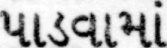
પાડવામાં
